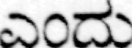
ಎಂದು
